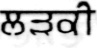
ਲੜਕੀ
